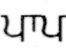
ਪਾਪ
